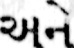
અને
